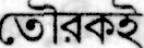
তৌরকই
